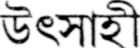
উত্সাহী
